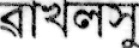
ৱাখলসু
